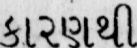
કારણથી
